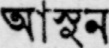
আসুন
